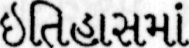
ઇતિહાસમાં
